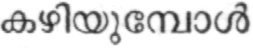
കഴിയുമ്പോള്‍
